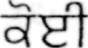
ਕੋਈ
